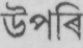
উপৰি
